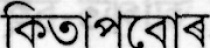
কিতাপবোৰ
